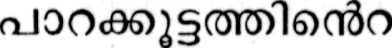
പാറക്കൂട്ടത്തിന്റെ
